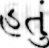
હતું
